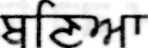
ਬਣਿਆ
